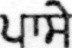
ਪਾਸੇ
